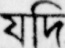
যদি
